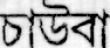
চাউবা
